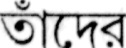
তাঁদের
